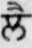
ਲੈ
